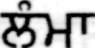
ਲੰਮਾ
